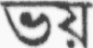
ভয়
